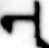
ન
